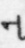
ન
